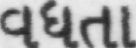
વધતા
